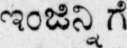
ಇಂಜಿನ್ನಿಗೆ
